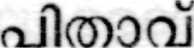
പിതാവ്
